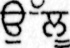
ਉੱਲੂ
